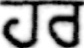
ਹਰ
